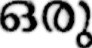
ഒരു
